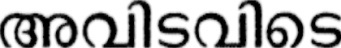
അവിടവിടെ
